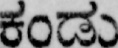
ಕಂಡು
